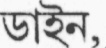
ডাইন,
